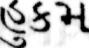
હુકમ
